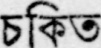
চকিত
